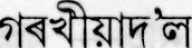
গৰখীয়াদ'ল
